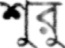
শুরু
